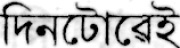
দিনটোৱেই
